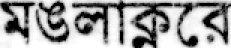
মঙলাক্নরে
